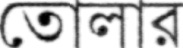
তোলার
